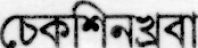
চেকশিনখ্রবা
